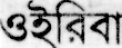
ওইরিবা
